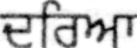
ਦਰਿਆ
